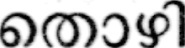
തൊഴി
